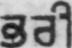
ਭਰੀ
